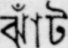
ঝাঁট
